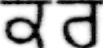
ਕਰ
